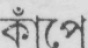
কাঁপে
